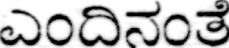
ಎಂದಿನಂತೆ
